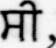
ਸੀ,
